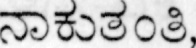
ನಾಕುತಂತಿ,
